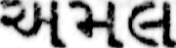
અમલ
